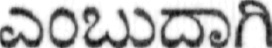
ಎಂಬುದಾಗಿ
